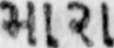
મારા
